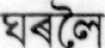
ঘৰলৈ
